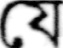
যে
